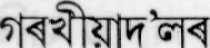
গৰখীয়াদ'লৰ
